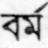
বর্ম
